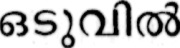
ഒടുവില്‍
